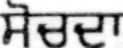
ਸੋਚਦਾ
